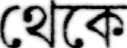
থেকে
